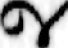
જ
